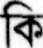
কি
